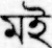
মই
